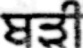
ਬੜੀ
